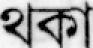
থকা
